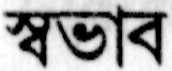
স্বভাব
